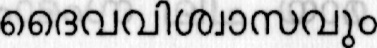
ദൈവവിശ്വാസവും
